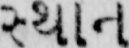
સ્થાન
